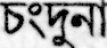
চংদুনা
